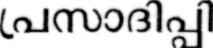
പ്രസാദിപ്പി
